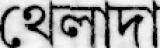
থেলাদা
